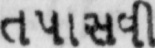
તપાસવી
